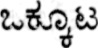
ಒಕ್ಕೂಟ
